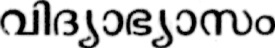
വിദ്യാഭ്യാസം
